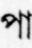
পা
